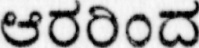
ಆರರಿಂದ
